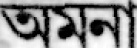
অমনা
